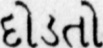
દોડતો
